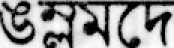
ঙম্লমদে
